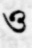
ও
